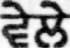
ਵੇਲੇ
